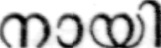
നായി
